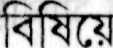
বিষিয়ে
